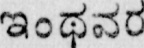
ಇಂಥವರ
